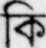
কি
